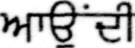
ਆਉਂਦੀ
